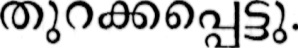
തുറക്കപ്പെട്ടു.
